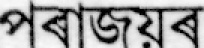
পৰাজয়ৰ
